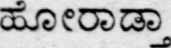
ಹೋರಾಡ್ತಾ
